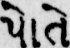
પોતે
